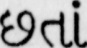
છતાં
